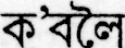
ক'বলৈ
